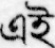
এই
